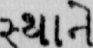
સ્થાને
